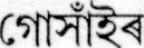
গোসাঁইৰ
